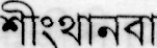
শীংথানবা
